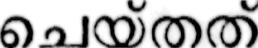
ചെയ്തത്
